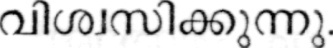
വിശ്വസിക്കുന്നു.
